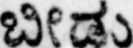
ಬೀಡು
